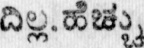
ದಿಲ್ಲ.ಹೆಚ್ಚು
